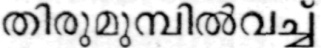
തിരുമുമ്പില്‍വച്ച്
